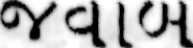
જવાબ
